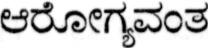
ಆರೋಗ್ಯವಂತ
